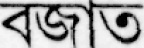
বজাত
